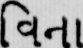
વિના
